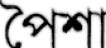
পৈশা
